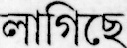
লাগিছে
